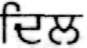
ਦਿਲ
